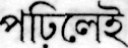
পঢ়িলেই
